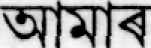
আমাৰ
